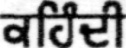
ਕਹਿੰਦੀ
